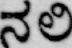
ನಲಿ
